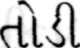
તોડી
